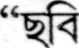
“ছবি
